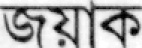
জয়াক
